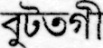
বুটতগী
